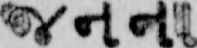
જનના
